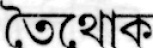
তৈথোক
